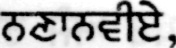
ਨਣਾਨਵੀਏ,
